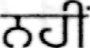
ਨਹੀਂ
